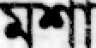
মশা
